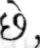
છે,
